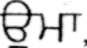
ਉਮਾ,
